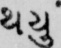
થયું
